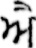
ਐ
